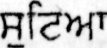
ਸੁਟਿਆ
